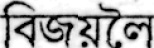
বিজয়লৈ
